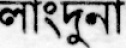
লাংদুনা
